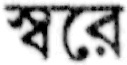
স্বরে
